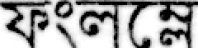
ফংলম্লে
